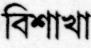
বিশাখা
